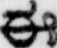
ಈ
